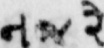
નજરે
